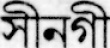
সীনগী
